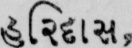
હરિદાસ,
